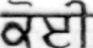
ਕੋਈ
